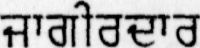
ਜਾਗੀਰਦਾਰ
